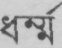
ধৰ্ম্ম
